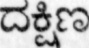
ದಕ್ಷಿಣ
